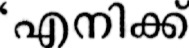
‘എനിക്ക്
